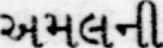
અમલની
